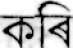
কৰি
